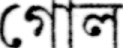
গোল
